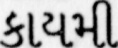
કાયમી
